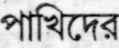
পাখিদের
